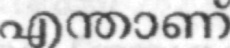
എന്താണ്
